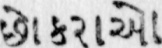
છોકારોઓ
